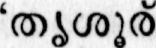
‘തൃശൂര്
